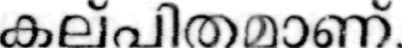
കല്പിതമാണ്.
